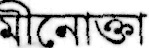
মীনোক্তা
